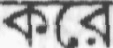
করে
